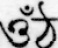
ওঁঠ
